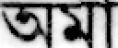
অমা
